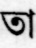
তা
